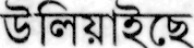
উলিয়াইছে
